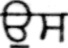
ਉਸ
